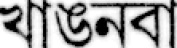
খাঙনবা
